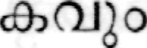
കവും
